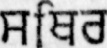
ਸਥਿਰ
